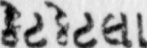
કેટકેટલાં
